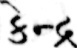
કેન્દ્ર
